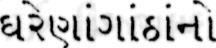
ઘરેણાંગાંઠાંનો
